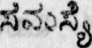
ಸಮಸ್ಯೆ
